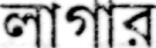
লাগার
